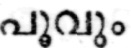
പൂവും
